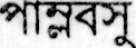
পাম্লবসু
